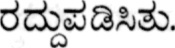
ರದ್ದುಪಡಿಸಿತು.
